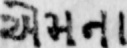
એમના
